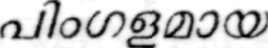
പിംഗളമായ
